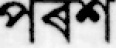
পৰশ
